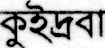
কুইদ্রবা
